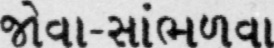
જોવા-સાંભળવા
